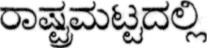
ರಾಷ್ಟ್ರಮಟ್ಟದಲ್ಲಿ
